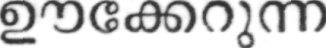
ഊക്കേറുന്ന
